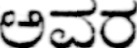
ಅವರ
